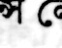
পুন্সি
